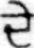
ਦੇ
